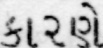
કારણે
